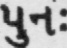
પુનઃ
